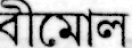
বীমোল
